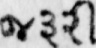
જરૂરી
